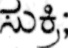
ಸುಕ್ರಿ;
